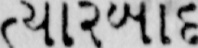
ત્યારબાદ
